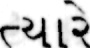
ત્યારે
